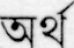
অর্থ
